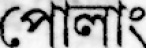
পোলাং
